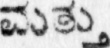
ಮತ್ತು
